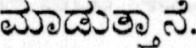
ಮಾಡುತ್ತಾನೆ.
